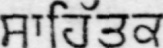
ਸਾਹਿੱਤਕ
